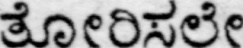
ತೋರಿಸಲೇ
